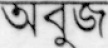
অবুজ
